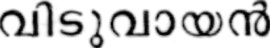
വിടുവായന്‍
